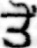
ਤੋਂ
